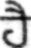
ਹੈ
